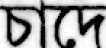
চাদে
